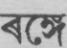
ৰঙ্গে
